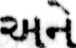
અને
